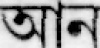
আন
